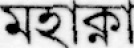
মহাক্না
